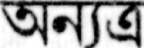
অন্যত্র
